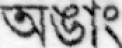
অঙাং
